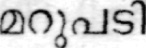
മറുപടി
